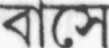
বাসে
